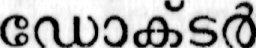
ഡോക്ടര്‍
